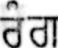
ਰੰਗ
